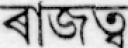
ৰাজত্ব
